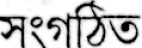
সংগঠিত
